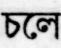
চলে
